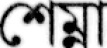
শেম্না
